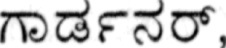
ಗಾರ್ಡನರ್,
